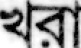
খরা
